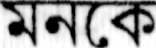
মনকে
